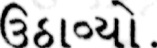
ઉઠાવ્યો.
